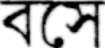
বসে
